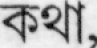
কথা,
